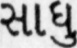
સાધુ
